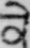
ਕੇ
